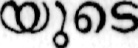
യുടെ
